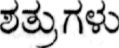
ಶತ್ರುಗಳು
